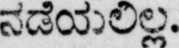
ನಡೆಯಲಿಲ್ಲ.
